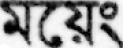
ময়েং
